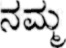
ನಮ್ಮ
